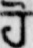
ਹੋ
